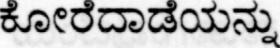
ಕೋರೆದಾಡೆಯನ್ನು
